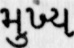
મુખ્ય
